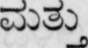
ಮತ್ತು
